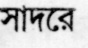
সাদরে
